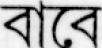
বাবে
